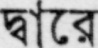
দ্বারে
